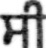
ਸੀ
